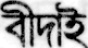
বীদাই
